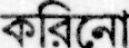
করিনো
